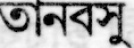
তানবসু
